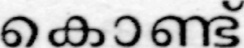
കൊണ്ട്
